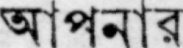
আপনার
